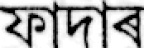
ফাদাৰ
